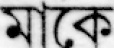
মাকে
